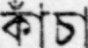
কাঁচা
